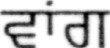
ਵਾਂਗ
